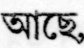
আছে,
